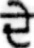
ਦੇ
